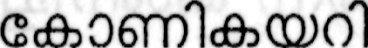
കോണികയറി
